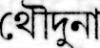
থৌদুনা
